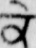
ਕੇ
